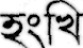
হংখি
